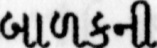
બાળકની
